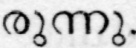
രുന്നു.
